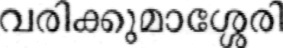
വരിക്കുമാശ്ശേരി
